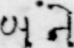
બંને
